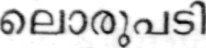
ലൊരുപടി
